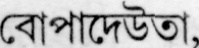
বোপাদেউতা,
